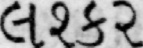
લશ્કર
